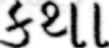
કથા
